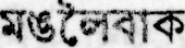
মঙলৈবাক
